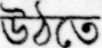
উঠতে
